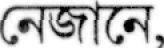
নেজানে,
